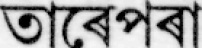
তাৰেপৰা
